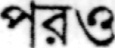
পরও
